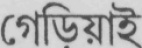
গেড়িয়াই
